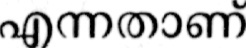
എന്നതാണ്
